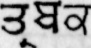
ਤ੍ਰਬਕ
